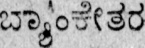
ಬ್ಯಾಂಕೇತರ
